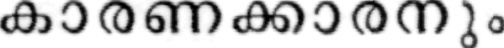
കാരണക്കാരനും
